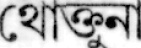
থোক্তুনা
